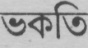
ভকতি
